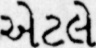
એટલે
